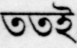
ততই
